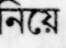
নিয়ে
